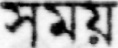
সময়
